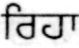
ਰਿਹਾ
